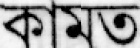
কামত
